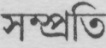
সম্প্ৰতি
